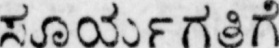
ಸೂರ್ಯಗತಿಗೆ
